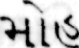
મોહ
